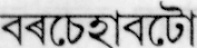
বৰচেহাবটো
